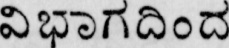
ವಿಭಾಗದಿಂದ
